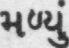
મળ્યું
